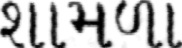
શામળા
